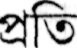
প্রতি
